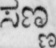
ಸಣ್ಣ
